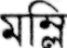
মম্লি
